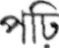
পঢ়ি
